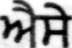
ਐਸੇ
